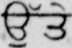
ਉੱਤੇ
